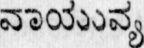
ವಾಯುವ್ಯ
